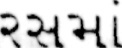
રસમાં
